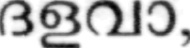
ദളവാ,
